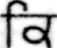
ਕਿ
